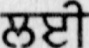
ਲਈ
